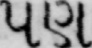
પણ
